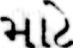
માટે
